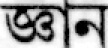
জ্ঞান
